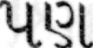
પણ
